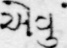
એવું
